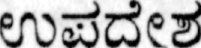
ಉಪದೇಶ
